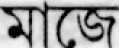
মাজে
